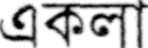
একলা
